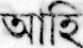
আহি
